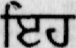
ਇਹ
